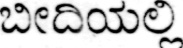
ಬೀದಿಯಲ್ಲಿ
